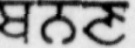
ਬਨਣ
